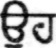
ਉਹ
